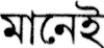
মানেই
